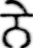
ਨੇ
